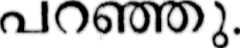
പറഞ്ഞു.
